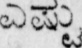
ಎಷ್ಟು
